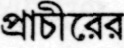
প্রাচীরের
